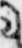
યે
